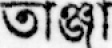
তাঞ্জা
